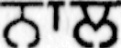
ਨਾਲ
